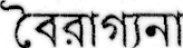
বৈরাগ্যনা
